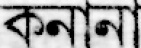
কনানা
